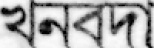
খনবদা
